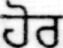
ਹੋਰ
